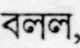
বলল,
